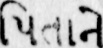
પિતાને
